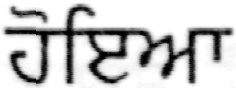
ਹੋਇਆ
